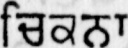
ਚਿਕਨਾ
